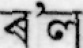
ৰ'ল
